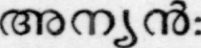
അന്യന്‍:
